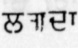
ਲਗਦਾ
